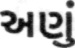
અણું
